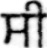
ਸੀ
